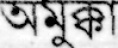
অমুক্কা
